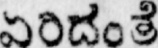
ಏರಿದಂತೆ
